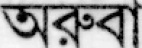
অরুবা
